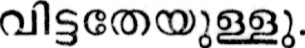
വിട്ടതേയുള്ളു.
